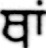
ਥਾਂ
